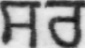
ਸਰ
